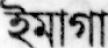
ইমাগা
